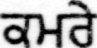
ਕਮਰੇ
